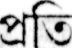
প্রতি
